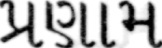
પ્રણામ
